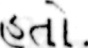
હતો.
